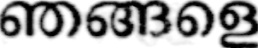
ഞങ്ങളെ
